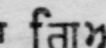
ਗਿ
